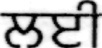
ਲਈ
